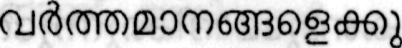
വര്‍ത്തമാനങ്ങളെക്കു
